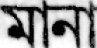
মানা
